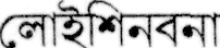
লোইশিনবনা
